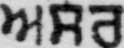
ਅਸਰ
